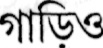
গাড়িও
